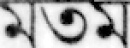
মতম
